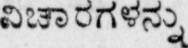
ವಿಚಾರಗಳನ್ನು
